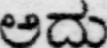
ಅದು
